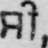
ਸੀ,
